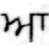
ਆ
